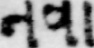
નવા
